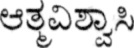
ಆತ್ಮವಿಶ್ವಾಸಿ
